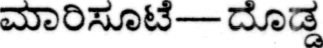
ಮಾರಿಸೂಟೆ-ದೊಡ್ಡ
